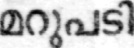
മറുപടി
